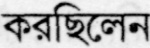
করছিলেন
